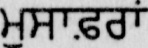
ਮੁਸਾਫ਼ਰਾਂ
